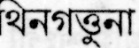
থিনগত্তুনা
